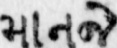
માનજે
